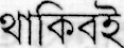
থাকিবই
